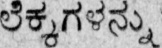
ಲೆಕ್ಕಗಳನ್ನು
